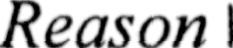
Reason।
